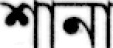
শানা
